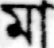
মা
